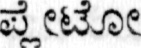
ಪ್ಲೇಟೋ
